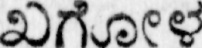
ಖಗೋಳ
